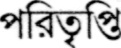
পরিতৃপ্তি
